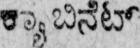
ಕ್ಯಾಬಿನೆಟ್
